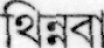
থিন্নবা
